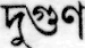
দুগুণ
